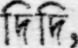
দিদি,
